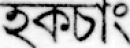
হকচাং
